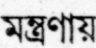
মন্ত্রণায়
